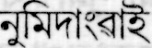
নুমিদাংৱাই
